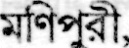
মণিপুরী,
